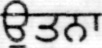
ਉਤਨਾ
